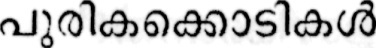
പുരികക്കൊടികള്‍
